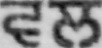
ਵਲ
